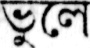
ভুলে
